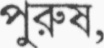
পুরুষ,
